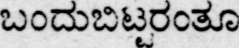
ಬಂದುಬಿಟ್ಟರಂತೂ
